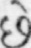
છે
